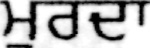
ਮੁਰਦਾ
